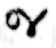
જ
